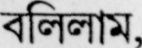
বলিলাম,
